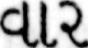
વાર
